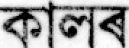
কালৰ
